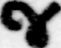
જ
